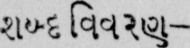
શબ્દવિવરણ-
